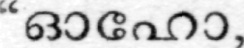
"ഓഹോ,
